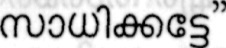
സാധിക്കട്ടേ"
